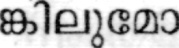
ങ്കിലുമോ
